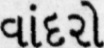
વાંદરો
